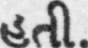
હતી.
